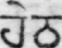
ਹੇਠ
